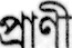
প্রাণী
